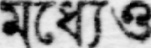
মধ্যেও
